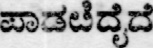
ಪಾಡೞೆದೈದೆ
